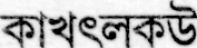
কাখৎলকউ
